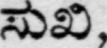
ಸುಖಿ,
